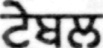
ਟੇਬਲ
